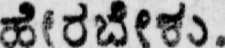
ಹೇರಬೇಕು.
